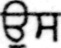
ਉਸ
